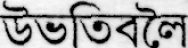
উভতিবলৈ
